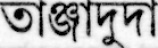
তাঞ্জাদুদা
